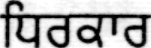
ਧਿਰਕਾਰ
